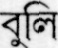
বুলি
